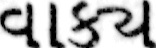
વાક્ય
